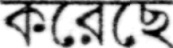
করেছে
